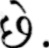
છે.
